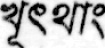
খূৎথাং
